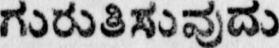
ಗುರುತಿಸುವುದು
